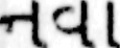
નવા
